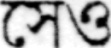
সেও
